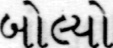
બોલ્યો
